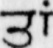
ਤਾਂ
